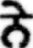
ਨੇ
